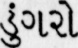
ડુંગરો
